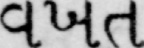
વખત
